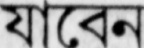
যাবেন
